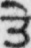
ਤੇ
